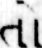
તો
